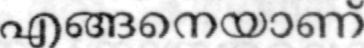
എങ്ങനെയാണ്
